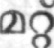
മറ്റ്
